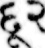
દૂર
